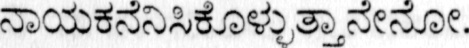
ನಾಯಕನೆನಿಸಿಕೊಳ್ಳುತ್ತಾನೇನೋ.
